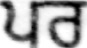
ਪਰ
